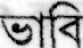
ভাবি
